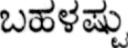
ಬಹಳಷ್ಟು
